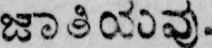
ಜಾತಿಯವು.
